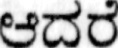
ಆದರೆ
